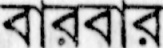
বারবার
